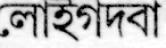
লোইগদবা
